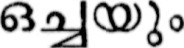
ഒച്ചയും
